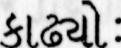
કાઢ્યોઃ
